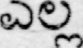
ಎಲ್ಲ
